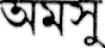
অমসু
